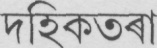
দহিকতৰা
